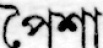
পৈশা
